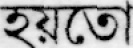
হয়তো
